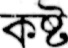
কষ্ট
